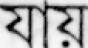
যায়
